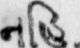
નહિ.
